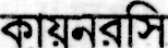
কায়নরসি
